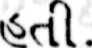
હતી.
